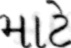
માટે
